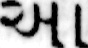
આ
